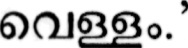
വെള്ളം.'
